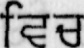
ਵਿਚ
